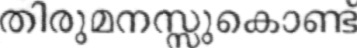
തിരുമനസ്സുകൊണ്ട്
